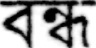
বন্ধ
